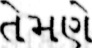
તેમણે
